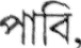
পাবি,
